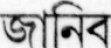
জানিব
